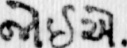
જોઈએ.
